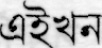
এইখন
